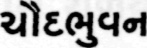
ચૌદભુવન
